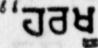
''ਹਰਖੂ
